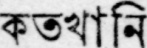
কতখানি
